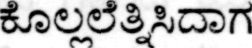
ಕೊಲ್ಲಲೆತ್ನಿಸಿದಾಗ
